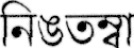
নিঙতম্বা
